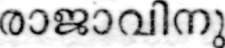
രാജാവിനു
